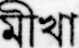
মীখা
